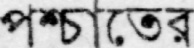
পশ্চাতের
